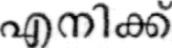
എനിക്ക്
